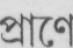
প্ৰাণে
